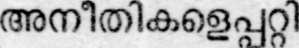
അനീതികളെപ്പറ്റി
